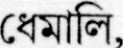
ধেমালি,
